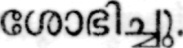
ശോഭിച്ചു.
